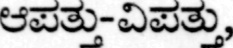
ಆಪತ್ತು-ವಿಪತ್ತು,
